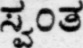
ಸ್ವಂತ
